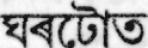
ঘৰটোত
